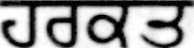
ਹਰਕਤ
